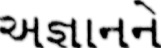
અજ્ઞાનને
